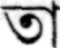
তা
